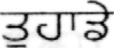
ਤੁਹਾਡੇ
